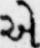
એ
